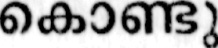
കൊണ്ടു
